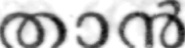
താന്‍
